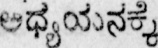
ಅಧ್ಯಯನಕ್ಕೆ
